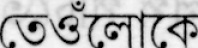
তেওঁলোকে
